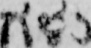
ಗಳು
